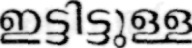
ഇട്ടിട്ടുള്ള
